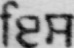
ਇਸ
